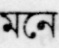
মনে
